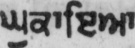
ਘੁਕਾਇਆ
